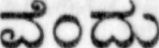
ವೆಂದು
